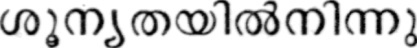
ശൂന്യതയില്‍നിന്നു
